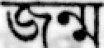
জন্ম
